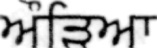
ਔੜਿਆ
